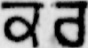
ਕਰ
